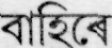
বাহিৰে
